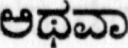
ಅಥವಾ
